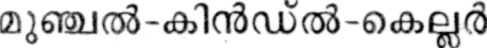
മുഞ്ചല്‍-കിന്‍ഡ്ല്‍-കെല്ലര്‍
